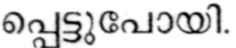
പ്പെട്ടുപോയി.
